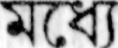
মধ্যে
